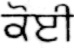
ਕੋਈ
